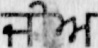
ਜੀਅ
